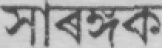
সাৰঙ্গক
